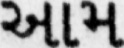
આમ
